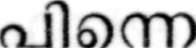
പിന്നെ
